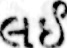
લઈ
